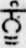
ਨੂੰ
